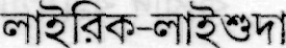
লাইরিক-লাইশুদা
